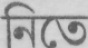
নিতে
